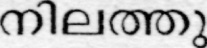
നിലത്തു
